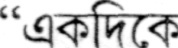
“একদিকে
